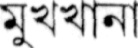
মুখখানা
